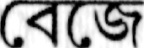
বেজে
